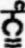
ਨੂੰ
